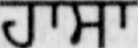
ਹਾਸਾ
